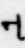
ન
